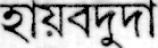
হায়বদুদা
